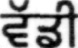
ਵੱਡੀ
